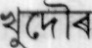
খুদৌৰ
